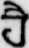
ਹੈ
